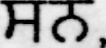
ਸਨ,
